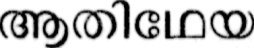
ആതിഥേയ
